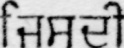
ਜਿਸਦੀ
